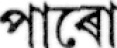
পাৰো
